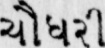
ચૌધરી
